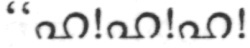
"ഹ!ഹ!ഹ!
